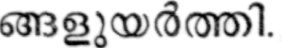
ങ്ങളുയര്‍ത്തി.
